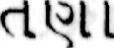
તણા
